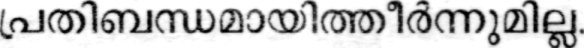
പ്രതിബന്ധമായിത്തീര്‍ന്നുമില്ല.
